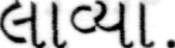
લાવ્યા.
